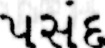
પસંદ
